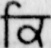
ਕਿ
